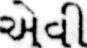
એવી
